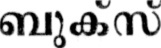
ബുക്സ്
